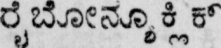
ರೈಬೋನ್ಯೂಕ್ಲಿಕ್
